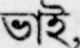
ভাই,
